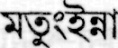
মতুংইন্না
